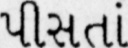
પીસતાં
